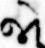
જો
